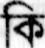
কি
